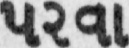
પરવા
